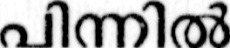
പിന്നില്‍
